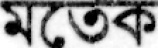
মতেক
